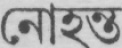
নোহন্ত
